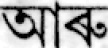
আৰু
